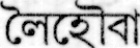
লৈহৌবা
